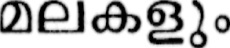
മലകളും
